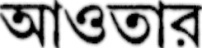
আওতার
